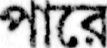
পারে
